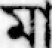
মা
